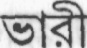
ভারী
